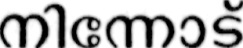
നിന്നോട്
